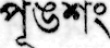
পূঙশং
